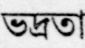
ভদ্রতা
